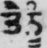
ਤੈਨੂੰ
